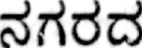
ನಗರದ
